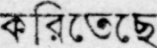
করিতেছে
